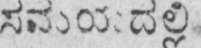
ಸಮಯದಲ್ಲಿ
